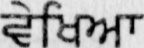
ਵੇਖਿਆ
